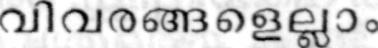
വിവരങ്ങളെല്ലാം
